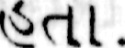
હતા.
